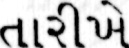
તારીખે
